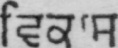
ਵਿਕਾਸ
